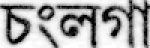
চংলগা
